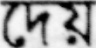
দেয়
